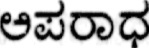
ಅಪರಾಧ
